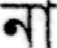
না
